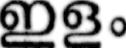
ഇളം
